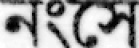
নংসে
